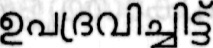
ഉപദ്രവിച്ചിട്ട്
